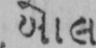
બોલ
